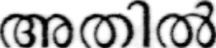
അതില്‍
